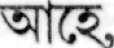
আহে,
